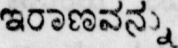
ಇರಾಣವನ್ನು
